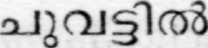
ചുവട്ടില്‍
